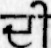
ਦੀ
